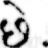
છે.
